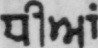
ਧੀਆਂ
